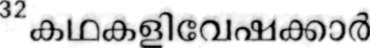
32കഥകളിവേഷക്കാര്‍
